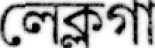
লেক্লগা
